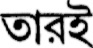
তারই
